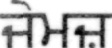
ਜੇਮਜ਼
